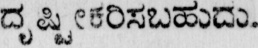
ದೃಷ್ಟೀಕರಿಸಬಹುದು.
